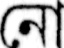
নো
